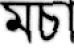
মচা
